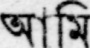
আমি
